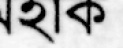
মহাক
